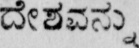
ದೇಶವನ್ನು
